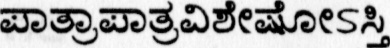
ಪಾತ್ರಾಪಾತ್ರವಿಶೇಷೋsಸ್ತಿ
